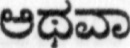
ಅಥವಾ
